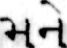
મને
